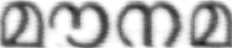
മൌനമ
